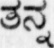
ತನ್ನ
